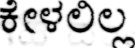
ಕೇಳಲಿಲ್ಲ
